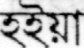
হইয়া
